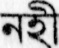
নহী
